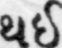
થઈ
